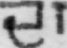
ਦਾ
